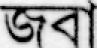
জবা
